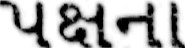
પક્ષના
